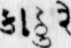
કાઠુરે
